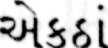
એકઠાં
